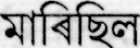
মাৰিছিল
